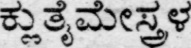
ಕ್ಲುತೈಮೇಸ್ತ್ರಳ
